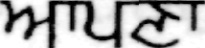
ਆਪਣਾ
